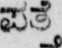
ಪತ್ತೆ
